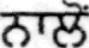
ਨਾਲੋਂ
